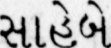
સાહેબે
